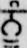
ਨੂੰ
